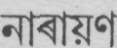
নাৰায়ণ
